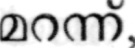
മറന്ന്,
